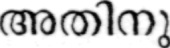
അതിനു
